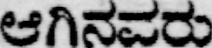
ಆಗಿನವರು
